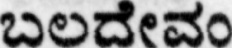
ಬಲದೇವಂ
